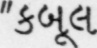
"કબૂલ
